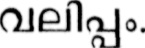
വലിപ്പം.
